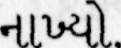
નાખ્યો.
